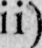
(ii)
